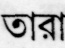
তারা
